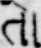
તો
